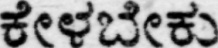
ಕೇಳಬೇಕು
